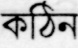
কঠিন
